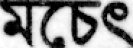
মচেৎ
